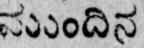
ಮುಂದಿನ
